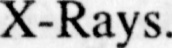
X-Rays,
